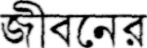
জীবনের
